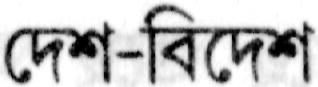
দেশ-বিদেশ
